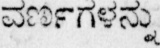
ವರ್ಣಗಳನ್ನು
